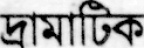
দ্রামাটিক
